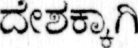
ದೇಶಕ್ಕಾಗಿ
